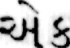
એક
